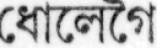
ধোলেগৈ
